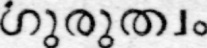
ഗുരുത്വം
